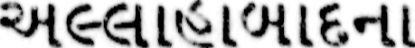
અલ્લાહાબાદના
